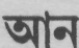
আন
